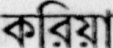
করিয়া
